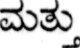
ಮತ್ತು
